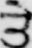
ਤੇ
